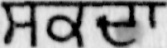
ਸਕਦਾ
